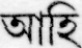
আহি
